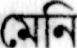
মেনি
